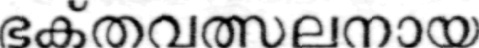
ഭക്തവത്സലനായ
